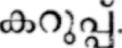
കറുപ്പ്.
